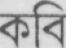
কবি
